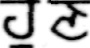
ਹੁਣ
